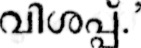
വിശപ്പ്.’
